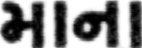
માના
